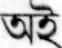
অই
